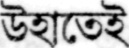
উহাতেই
